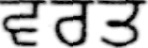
ਵਰਤ
